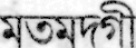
মতমদগী
